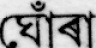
ঘোঁৰা
